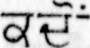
ਕਦੋਂ
